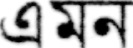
এমন
